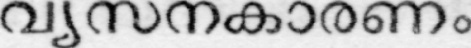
വ്യസനകാരണം
